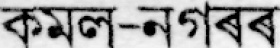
কমল-নগৰৰ
